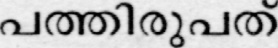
പത്തിരുപത്
